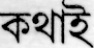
কথাই
